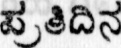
ಪ್ರತಿದಿನ
